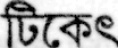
টিকেৎ
